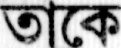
তাকে
